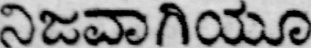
ನಿಜವಾಗಿಯೂ
